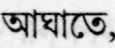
আঘাতে,
